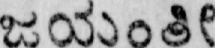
ಜಯಂತೀ
